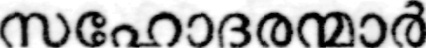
സഹോദരന്മാര്‍
